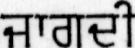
ਜਾਗਦੀ
